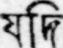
যদি
